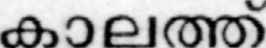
കാലത്ത്
